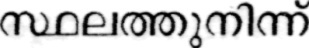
സ്ഥലത്തുനിന്ന്
